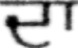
ਦਾ
